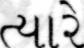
ત્યારે
